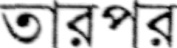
তারপর
